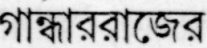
গান্ধাররাজের
